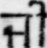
ਜੀ
